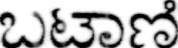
ಬಟಾಣಿ
